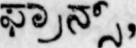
ಫ್ರಾನ್ಸ್,
